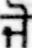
ਜੋ
